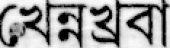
খেন্নখ্রবা
